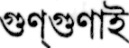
গুণ্‌গুণাই
